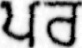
ਪਰ
